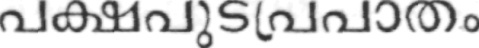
പക്ഷപുടപ്രപാതം
